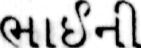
ભાઈની
